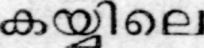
കയ്യിലെ
